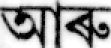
আৰু
